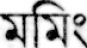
মমিং
